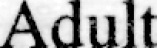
Adult
